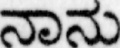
ನಾನು
